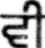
ਵੀ
